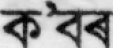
ক'বৰ
